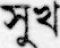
সুখ
